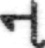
ન
